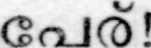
പേര്!
